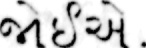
જોઈએ.
